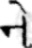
ને
